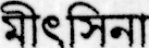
মীৎসিনা
